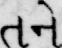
તને
